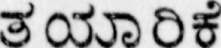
ತಯಾರಿಕೆ
